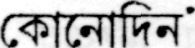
কোনোদিন
